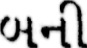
બની
